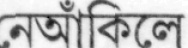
নেআঁকিলে
